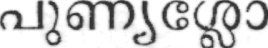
പുണ്യശ്ലോ
